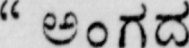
“ಅಂಗದ
